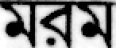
মরম
